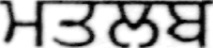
ਮਤਲਬ
